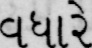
વધારે
